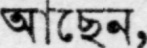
আছেন,
